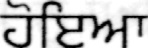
ਹੋਇਆ
